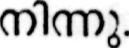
നിന്നു.
